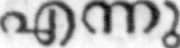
എന്നു
